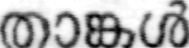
താങ്കള്‍
